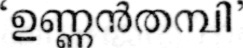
‘ഉണ്ണന്‍തമ്പി'
